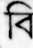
বি
